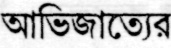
আভিজাত্যের
